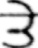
ਤੇ
